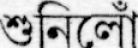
শুনিলোঁ
